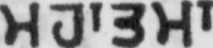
ਮਹਾਤਮਾ
